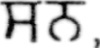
ਸਨ,
